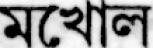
মখোল
